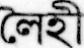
লৈহী
